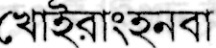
খোইরাংহনবা
